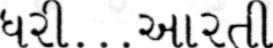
ધરી...આરતી
